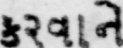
કરવાને
